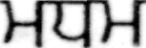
ਮਧਮ
